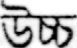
উচ্চ
